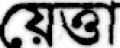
য়েত্তা
